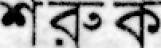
শরুক
